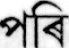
পৰি
